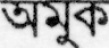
অমুক
